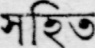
সহিত
